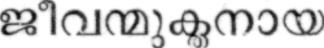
ജീവന്മുക്തനായ
